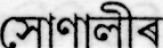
সোণালীৰ
